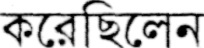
করেছিলেন
